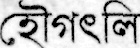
হৌগৎলি
